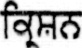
ਕ੍ਰਿਸ਼ਨ
